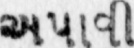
અપાવી
